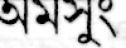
অমসুং
